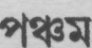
পঞ্চম
